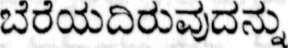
ಬೆರೆಯದಿರುವುದನ್ನು
